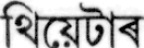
থিয়েটাৰ
